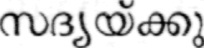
സദ്യയ്ക്കു
